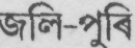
জলি-পুৰি
